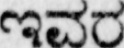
ಇವರ
